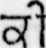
ਕੀ
